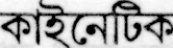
কাইনেটিক
